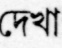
দেখা
